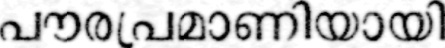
പൌരപ്രമാണിയായി
